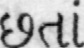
છતાં
